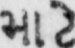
માટે
